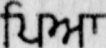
ਪਿਆ
